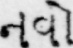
નવો
